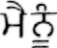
ਮੈਨੂੰ
